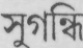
সুগন্ধি
